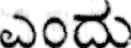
ಎಂದು
